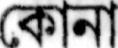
কোনা
